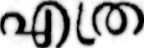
എത്ര
